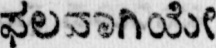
ಫಲವಾಗಿಯೇ
